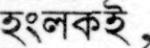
হংলকই,
